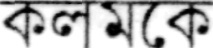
কলমকে
